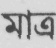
মাত্ৰ
